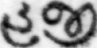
હજી
